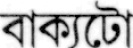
বাক্যটো
